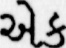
એક
